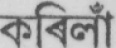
কৰিলাঁ
